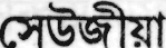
সেউজীয়া
